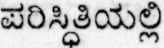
ಪರಿಸ್ಥಿತಿಯಲ್ಲಿ
